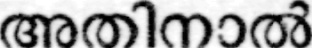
അതിനാല്‍
